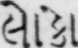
લોકો
